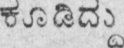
ಕೂಡಿದ್ದು
